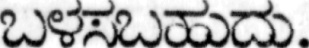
ಬಳಸಬಹುದು.
